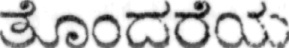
ತೊಂದರೆಯ
